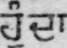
ਹੁੰਦਾ
